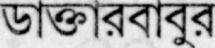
ডাক্তারবাবুর
